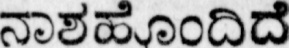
ನಾಶಹೊಂದಿದೆ
